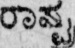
ರಾಷ್ಟ್ರ
